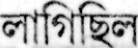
লাগিছিল
